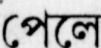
পেলে
